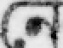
নে
